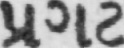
પ્રગટ
